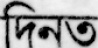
দিনত
